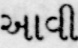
આવી
